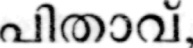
പിതാവ്,
